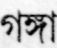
গঙ্গা
